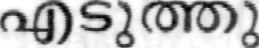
എടുത്തു
